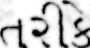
તરીકે
